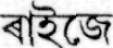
ৰাইজে
